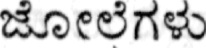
ಜೋಲೆಗಳು
